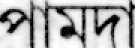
পামদা
